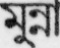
মুন্না
